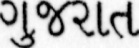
ગુજરાત
